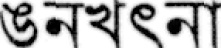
ঙনখৎনা
